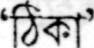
‘ঠিকা’
